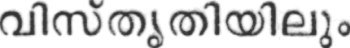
വിസ്തൃതിയിലും
